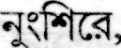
নুংশিরে,
